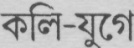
কলি-যুগে
